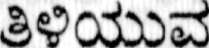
ತಿಳಿಯುವ
